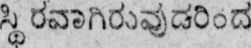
ಸ್ಥಿರವಾಗಿರುವುದರಿಂದ
